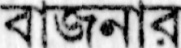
বাজনার
